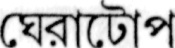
ঘেরাটোপ
